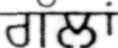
ਗੱਲਾਂ
